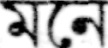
মনে
